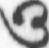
ও
